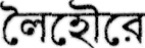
লৈহৌরে
